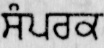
ਸੰਪਰਕ
